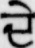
ਦੇ
